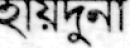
হায়দুনা
